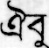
ঐবু
